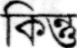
কিন্তু
